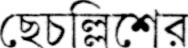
ছেচল্লিশের
